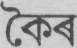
কৈৰ
